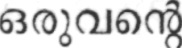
ഒരുവന്റെ
